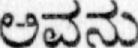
ಅವನು
